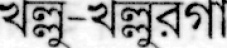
খল্লু-খল্লুরগা
